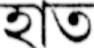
হাত
